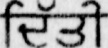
ਦਿੱਤੀ
